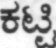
ಕಟ್ಟಿ
